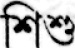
শিশু
